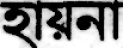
হায়না
